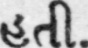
હતી.
